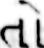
તો
